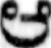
ಆ
